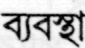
ব্যবস্থা
